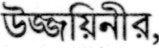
উজ্জয়িনীর,
